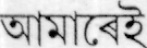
আমাৰেই
